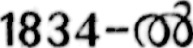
1834-ല്‍
